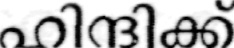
ഹിന്ദിക്ക്
